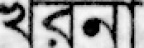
খরনা
